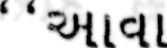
"આવા
